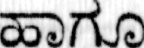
ಹಾಗೂ
